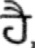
ਹੈ,
